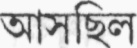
আসছিল
